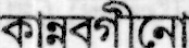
কান্নবগীনো
